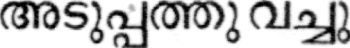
അടുപ്പത്തുവച്ചു
